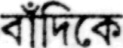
বাঁদিকে
